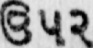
ઉપર
